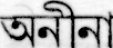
অনীনা
